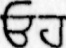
ਓਹ
